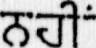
ਨਹੀਂ
